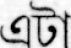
এটা
